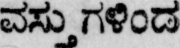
ವಸ್ತುಗಳಿಂದ
